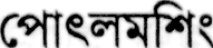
পোৎলমশিং
